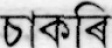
চাকৰি
